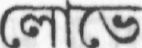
লোভে
